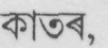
কাতৰ,
